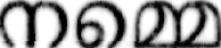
നമ്മെ
